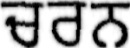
ਚਰਨ
